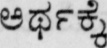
ಅರ್ಥಕ್ಕೆ
